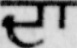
ਦਾ
